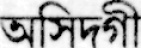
অসিদগী
